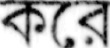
করে
